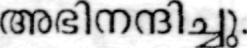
അഭിനന്ദിച്ചു.
